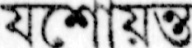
যশোয়ন্ত
